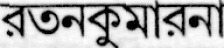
রতনকুমারনা
